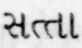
સત્તા
